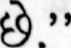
છે."
